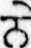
ਨੇ
